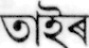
তাইৰ
